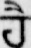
ਹੈ
